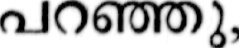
പറഞ്ഞു,
